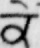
ਕੇ
